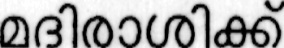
മദിരാശിക്ക്
